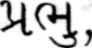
પ્રભુ,
